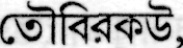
তৌরিরকউ,
